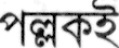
পল্লকই
